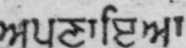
ਅਪਣਾਇਆ
